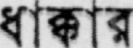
ধাক্কার
